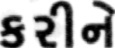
કરીને
